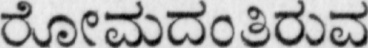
ರೋಮದಂತಿರುವ
